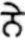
ਨੇ
